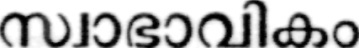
സ്വാഭാവികം
